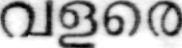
വളരെ
